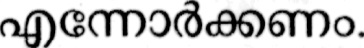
എന്നോര്‍ക്കണം.
